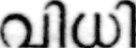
വിധി
